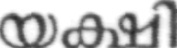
യക്ഷി
